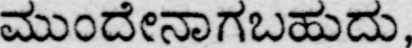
ಮುಂದೇನಾಗಬಹುದು,
